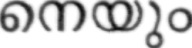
നെയും
